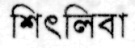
শিৎলিবা
